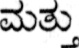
ಮತ್ತು
